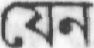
যেন
